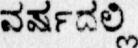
ವರ್ಷದಲ್ಲಿ
